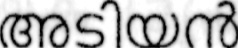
അടിയന്‍
